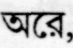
অরে,
